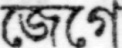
জেগে
